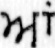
ਆਂ
